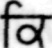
ਕਿ
